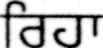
ਰਿਹਾ
